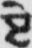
ਏ
